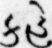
કહે
